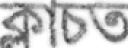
ক্লাচত
